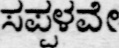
ಸಪ್ಪಳವೇ
